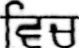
ਵਿਚ
